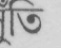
সুঁতি
